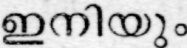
ഇനിയും
